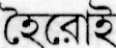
হৈরোই
